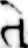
તે
